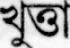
খু্ত্তা
